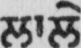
ਲਾਲੇ
